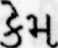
કેમ
